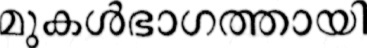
മുകള്‍ഭാഗത്തായി
